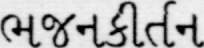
ભજનકીર્તન
